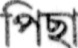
পিছা
